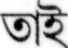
তাই
